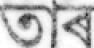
তাৰ
